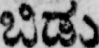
ಬಿಡು
